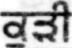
ਕੁੜੀ
